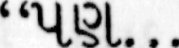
"પણ...
